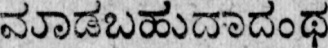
ಮಾಡಬಹುದಾದಂಥ
